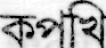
কপখি
